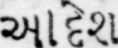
આદેશ
